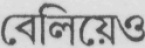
বেলিয়েও
